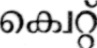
ക്വെറ്റ്
